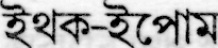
ইথক-ইপোম
